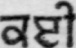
ਕਈ
